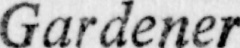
Gardener
